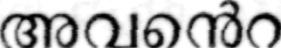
അവന്റെ
